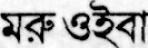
মরুওইবা
